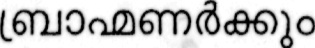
ബ്രാഹ്മണര്‍ക്കും
